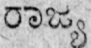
ರಾಜ್ಯ
